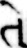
તે
